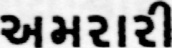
અમરારી
